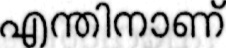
എന്തിനാണ്
